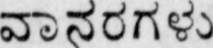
ವಾನರಗಳು
